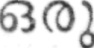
ഒരു
